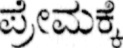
ಪ್ರೇಮಕ್ಕೆ
